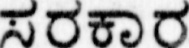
ಸರಕಾರ
